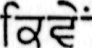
ਕਿਵੇਂ
